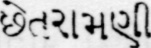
છેતરામણી
